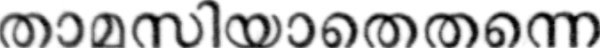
താമസിയാതെതന്നെ
